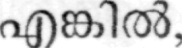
എങ്കില്‍,
